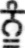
ਨੂੰ
